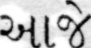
આજે
